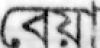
বেয়া
